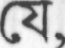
যে,
